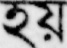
হয়
